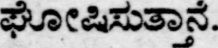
ಘೋಷಿಸುತ್ತಾನೆ.
